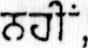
ਨਹੀਂ,
